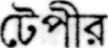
টেপীর
